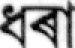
ধৰা
